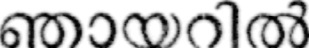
ഞായറില്‍
